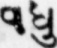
વધુ
